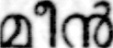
മീന്‍
